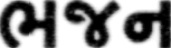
ભજન
